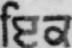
ਇਕ
